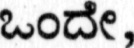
ಒಂದೇ,
